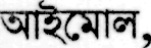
আইমোল,
